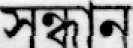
সন্ধান
